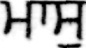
ਮਾਸੁ
